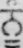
ਨੂੰ
